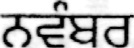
ਨਵੰਬਰ
